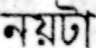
নয়টা
